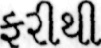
ફરીથી
